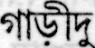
গাড়ীদু
